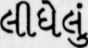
લીધેલુ
